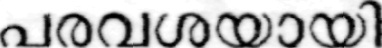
പരവശയായി
